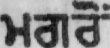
ਮਗਰੋਂ
